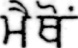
ਮੈਥੋਂ
